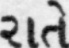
રાતે
